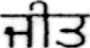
ਜੀਤ
